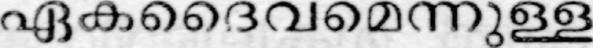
ഏകദൈവമെന്നുള്ള
